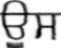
ਉਸ
